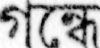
গন্ধে
